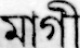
মাগী
